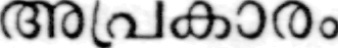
അപ്രകാരം
